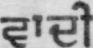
ਵਾਦੀ
